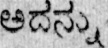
ಅದನ್ನು
